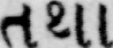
તથા
